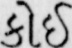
કોઈ
